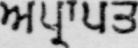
ਅਪ੍ਰਾਪਤ
